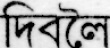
দিবলৈ
